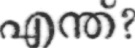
എന്ത്?
